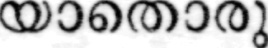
യാതൊരു
